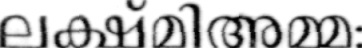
ലക്ഷ്മിഅമ്മ:
